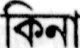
কিনা
